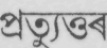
প্ৰত্যুত্তৰ
